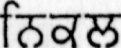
ਨਿਕਲ
